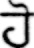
ਹੋ
